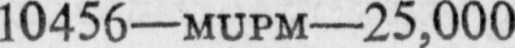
10456-Mutm-25,000
